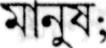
মানুষ;
